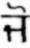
ਜੋ
